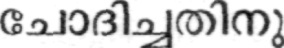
ചോദിച്ചതിനു
